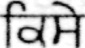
ਕਿਸੇ
